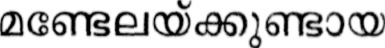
മണ്ടേലയ്ക്കുണ്ടായ
